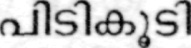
പിടികൂടി
